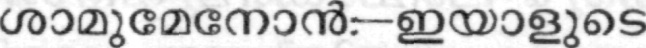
ശാമുമേനോന്‍:-ഇയാളുടെ
